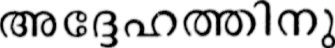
അദ്ദേഹത്തിനു
